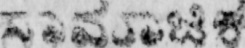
ಸಾಮಾಜಿಕ
